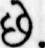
છે.
